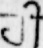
ਹੀ
